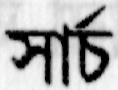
সার্চ
